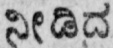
ನೀಡಿದ
